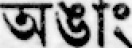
অঙাং
